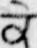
ਕੇ
